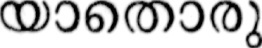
യാതൊരു
